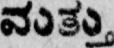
ಮತ್ತು
